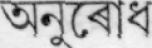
অনুৰোধ
